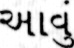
આવું
